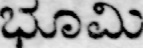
ಭೂಮಿ
